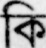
কি
